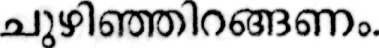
ചുഴിഞ്ഞിറങ്ങണം.
